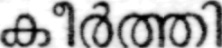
കീര്‍ത്തി
